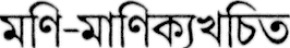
মণি-মাণিক্যখচিত
